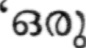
'ഒരു
